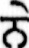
ਨੇ
